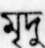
মৃদু
